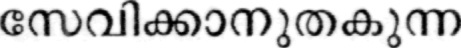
സേവിക്കാനുതകുന്ന
